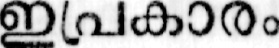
ഇപ്രകാരം
